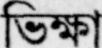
ভিক্ষা
